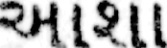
આશા
